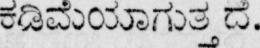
ಕಡಿಮೆಯಾಗುತ್ತದೆ.
